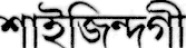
শাইজিন্দগী
